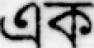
এক
